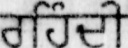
ਰਹਿੰਦੀ
